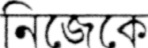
নিজেকে
